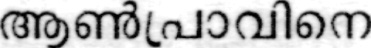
ആണ്‍പ്രാവിനെ
